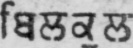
ਬਿਲਕੁਲ
